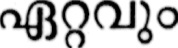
ഏറ്റവും
